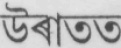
উৰাতত
